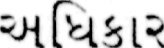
અધિકાર
